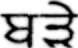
ਬੜੇ
